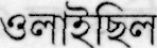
ওলাইছিল
